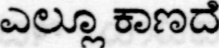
ಎಲ್ಲೂಕಾಣದೆ
